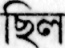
ছিল
